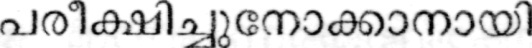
പരീക്ഷിച്ചുനോക്കാനായി
